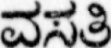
ವಸತಿ
